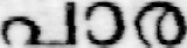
പാര
